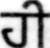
ਹੀ
